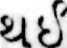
થઇ
